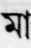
মা
